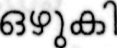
ഒഴുകി
